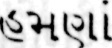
હમણાં
